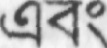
এবং
